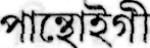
পান্থোইগী
